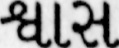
શ્વાસ
